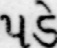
પડે
